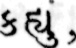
કહ્યું,
